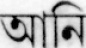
আনি
